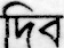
দিব
